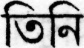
তিনি
